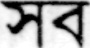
সব
